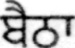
ਬੈਠਾ
